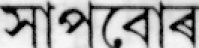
সাপবোৰ
